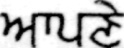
ਆਪਣੇ
